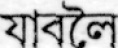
যাবলৈ
